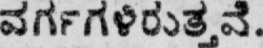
ವರ್ಗಗಳಿರುತ್ತವೆ.
